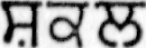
ਸ਼ਕਲ
